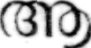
ആ
